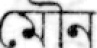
মৌন
